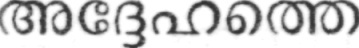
അദ്ദേഹത്തെ
